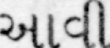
આવી
